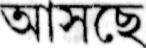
আসছে
